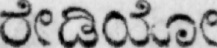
ರೇಡಿಯೋ
